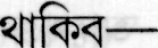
থাকিব-
